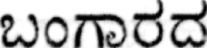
ಬಂಗಾರದ
